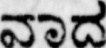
ವಾದ
